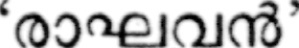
‘രാഘവന്‍'
